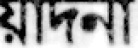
য়াদনা
